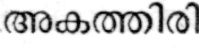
അകത്തിരി
